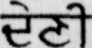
ਦੇਣੀ
